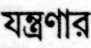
যন্ত্রণার
